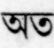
অত
